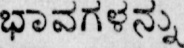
ಭಾವಗಳನ್ನು
